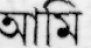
আমি
